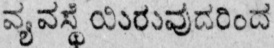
ವ್ಯವಸ್ಥೆಯಿರುವುದರಿಂದ
